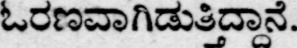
ಓರಣವಾಗಿಡುತ್ತಿದ್ದಾನೆ.
